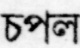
চপল
